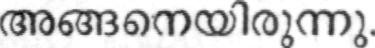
അങ്ങനെയിരുന്നു.
